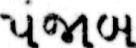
પંજાબ
